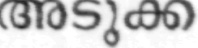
അടുക്ക
